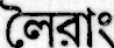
লৈরাং
